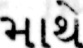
માથે
